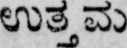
ಉತ್ತಮ
